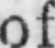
of
